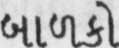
બાળકો
